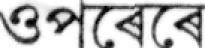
ওপৰেৰে
